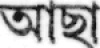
আছা
